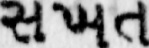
સખત
